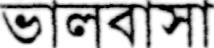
ভালবাসা
